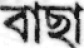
বাছা
